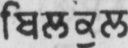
ਬਿਲਕੁਲ
